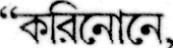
“করিনোনে,
